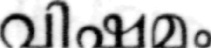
വിഷമം
